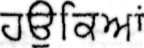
ਹਉਕਿਆਂ
